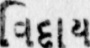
વિદાય
